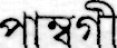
পাম্বগী
